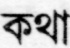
কথা
